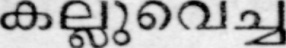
കല്ലുവെച്ച
